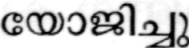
യോജിച്ചു
